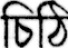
চিঠি
